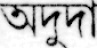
অদুদা
